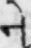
ને
